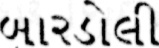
બારડોલી
